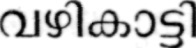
വഴികാട്ടി
